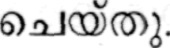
ചെയ്തു.
